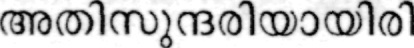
അതിസുന്ദരിയായിരി
